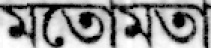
মতোমতা
